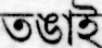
তঙাই
